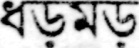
ধড়মড়
